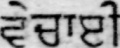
ਵੇਚਾਈ
